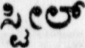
ಸ್ಟೀಲ್
